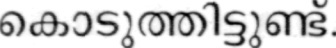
കൊടുത്തിട്ടുണ്ട്.
